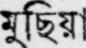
মুছিয়া
